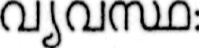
വ്യവസ്ഥ:
